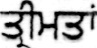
ਤ੍ਰੀਮਤਾਂ
